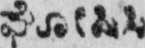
ಘೋಷಿಸಿ
